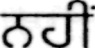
ਨਹੀਂ
